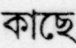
কাছে
